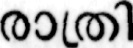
രാത്രി
